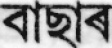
বাছাৰ
